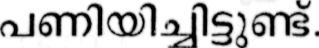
പണിയിച്ചിട്ടുണ്ട്.
